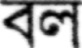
বল
